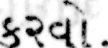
કરવો.
